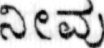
ನೀವು
